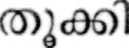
തൂക്കി
